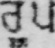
ਰੂਪ
